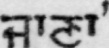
ਜਾਣਾ'
